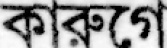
কারুগে
